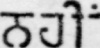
ਨਹੀਂ
